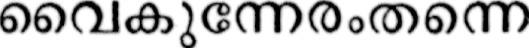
വൈകുന്നേരംതന്നെ
